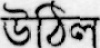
উঠিল
